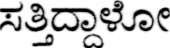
ಸತ್ತಿದ್ದಾಳೋ
